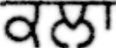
ਕਲਾ
